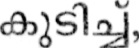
കുടിച്ച്,
